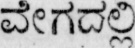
ವೇಗದಲ್ಲಿ
